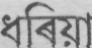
ধৰিয়া
